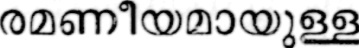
രമണീയമായുള്ള
